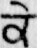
ਕੇ
